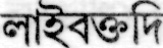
লাইবক্তদি
